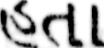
હતા
